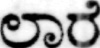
ಲಾರೆ
